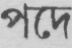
পদে
